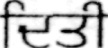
ਦਿਤੀ
